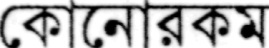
কোনোরকম
